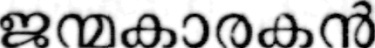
ജന്മകാരകന്‍
